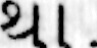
થા.
